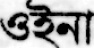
ওইনা
